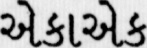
એકાએક
